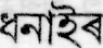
ধনাইৰ
